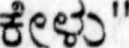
ಕೇಳು”
